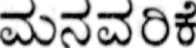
ಮನವರಿಕೆ
